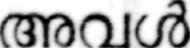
അവള്‍
